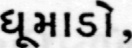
ધૂમાડો,
